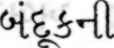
બંદૂકની
